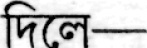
দিলে-
